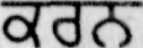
ਕਰਨ
